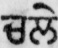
ਚਲੇ
